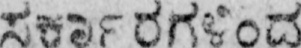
ಸರ್ಕಾರಗಳಿಂದ
